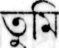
তুমি
